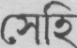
সেহি
